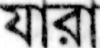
যারা
